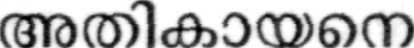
അതികായനെ
